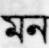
মন
